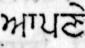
ਆਪਣੇ
